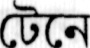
টেনে
